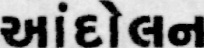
આંદોલન
